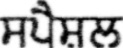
ਸਪੈਸ਼ਲ
